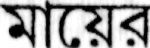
মায়ের
